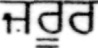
ਜ਼ਰੂਰ
